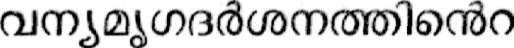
വന്യമൃഗദര്‍ശനത്തിന്റെ
